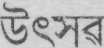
উৎসৱ
